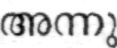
അന്നു
